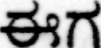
ಈಗ
